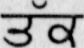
ਤੱਕ
